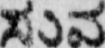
ಸುವ
